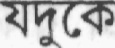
যদুকে
